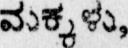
ಮಕ್ಕಳು,
